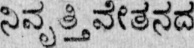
ನಿವೃತ್ತಿವೇತನದ
